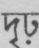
দৃঢ়
